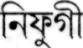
নিফুগী
